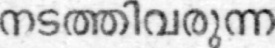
നടത്തിവരുന്ന
